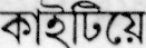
কাইটিয়ে
